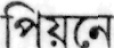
পিয়নে
